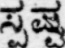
ಸ್ಪಷ್ಟ
